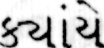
ક્યાંયે
